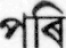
পৰি
